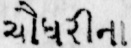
ચૌધરીના
